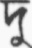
দু
